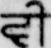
ਵੀ
